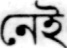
নেই
